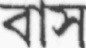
বাস
